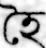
হৈ
